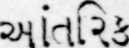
આંતરિક
